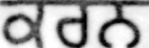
ਕਰਨ
